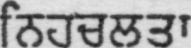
ਨਿਹਚਲਤਾ
